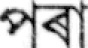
পৰা
